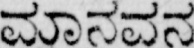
ಮಾನವನ
